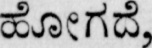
ಹೋಗದೆ,
